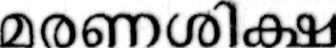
മരണശിക്ഷ
